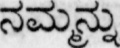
ನಮ್ಮನ್ನು
